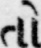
તો
